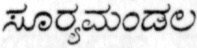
ಸೂರ್‍ಯಮಂಡಲ
